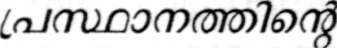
പ്രസ്ഥാനത്തിന്റെ
